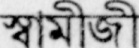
স্বামীজী
